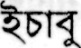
ইচাবু
